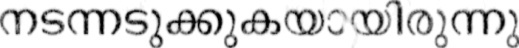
നടന്നടുക്കുകയായിരുന്നു
